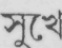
সুখে
